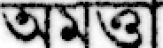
অমত্তা
